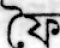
ফৈ
